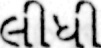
લીધી
